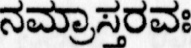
ನಮ್ರಾಸ್ತರವಃ
